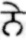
ਨੇ
